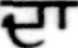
ਦਾ
